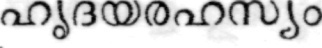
ഹൃദയരഹസ്യം
